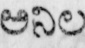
ಅನಿಲ
